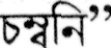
চম্বনি”
